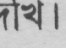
দেখি
